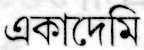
একাদেমি
